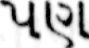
પણ
